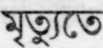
মৃত্যুতে
